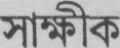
সাক্ষীক
